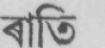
ৰাতি
